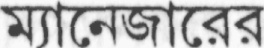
ম্যানেজারের
